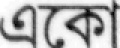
একো
